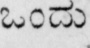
ಒಂದು
